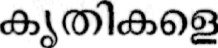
കൃതികളെ
